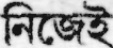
নিজেই
